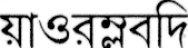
য়াওরম্লবদি
